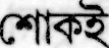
শোকই
